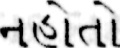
નહોતો
